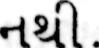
નથી.
